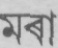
মৰা
